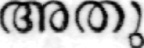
അതു
